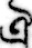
ঐ
